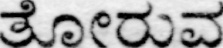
ತೋರುವ
